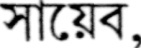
সায়েব,
